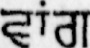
ਵਾਂਗ
